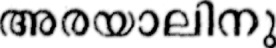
അരയാലിനു
